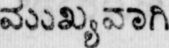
ಮುಖ್ಯವಾಗಿ
